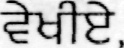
ਵੇਖੀਏ,
